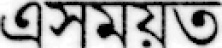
এসময়ত
